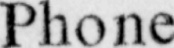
Phone
